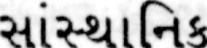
સાંસ્થાનિક
